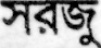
সরজু
